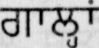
ਗਾਲ੍ਹਾਂ
